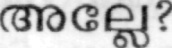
അല്ലേ?
